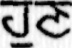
ਹੁਣ
